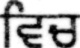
ਵਿਚ
